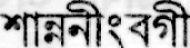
শান্ননীংবগী
